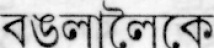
বঙলালৈকে
